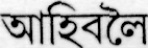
আহিবলৈ
